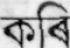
কৰি
